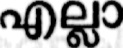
എല്ലാ
